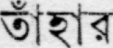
তাঁহার
